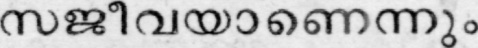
സജീവയാണെന്നും
